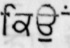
ਕਿਉਂ
